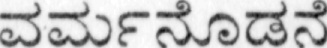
ವರ್ಮನೊಡನೆ
